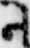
ને
